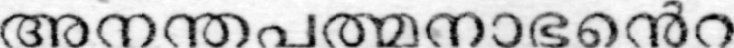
അനന്തപത്മനാഭന്റെ
